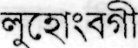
লুহোংবগী
